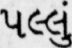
પલ્લું
